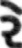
રે
